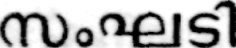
സംഘടി
